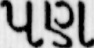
પણ
